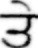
ਤੇ
